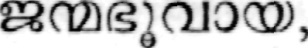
ജന്മഭൂവായ,
